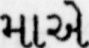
માએ
